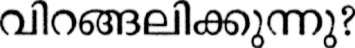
വിറങ്ങലിക്കുന്നു?
